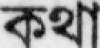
কথা
